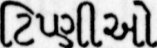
ટિપ્ણીએ
